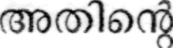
അതിന്റെ
